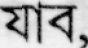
যাব,
